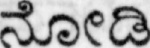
ನೋಡಿ
